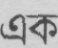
এক
